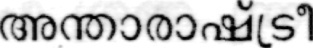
അന്താരാഷ്ട്രീ
